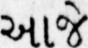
આજે
